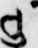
તું
